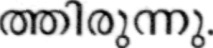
ത്തിരുന്നു.
